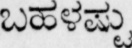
ಬಹಳಷ್ಟು
